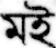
মই
